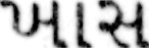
ખાસ
